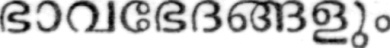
ഭാവഭേദങ്ങളും
